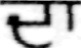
ਦਾ
